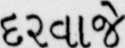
દરવાજે
